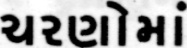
ચરણોમાં
